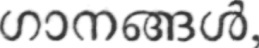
ഗാനങ്ങള്‍,
